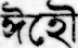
ঈহৌ
